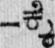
-ಕ್ಕೆ
